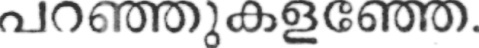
പറഞ്ഞുകളഞ്ഞേ.
